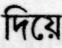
দিয়ে
